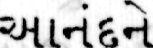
આનંદને
